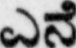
ಎನೆ
